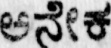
ಅನೇಕ
